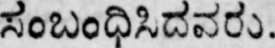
ಸಂಬಂಧಿಸಿದವರು.
